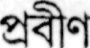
প্রবীণ
